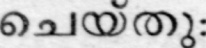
ചെയ്തു:
